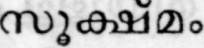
സൂക്ഷ്മം
